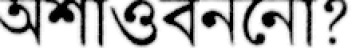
অশাওবননো?
